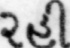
રહી
